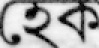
হেক
